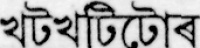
খটখটিটোৰ
